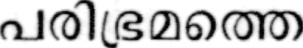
പരിഭ്രമത്തെ
